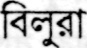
বিলুরা
